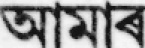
আমাৰ
